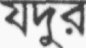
যদুর
